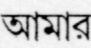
আমার
